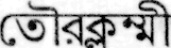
তৌরক্লম্মী
